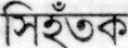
সিহঁতক
